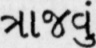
ત્રાજવું
